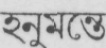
হনুমন্তে
